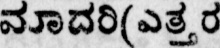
ಮಾದರಿ(ಎತ್ತರ
